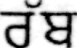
ਰੱਬ
